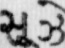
સૂઝે
